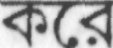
করে
